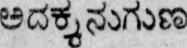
ಅದಕ್ಕನುಗುಣ
